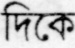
দিকে
